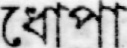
ধোপা
